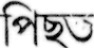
পিছত
